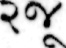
રજૂ
